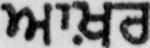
ਆਖ਼ਰ
